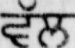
ਵੱਲ
